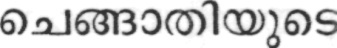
ചെങ്ങാതിയുടെ
